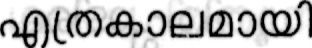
എത്രകാലമായി
